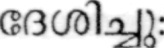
ദേശിച്ചു:
